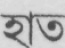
হাত
